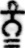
ਨੂੰ
